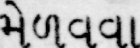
મેળવવા
